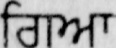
ਗਿਆ
